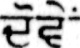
ਦੋਵੇਂ
